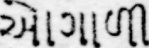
ઓગાળી
